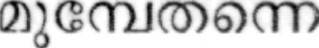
മുമ്പേതന്നെ
